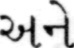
અને
